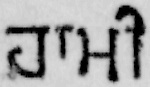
ਹਾਮੀ
